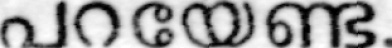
പറയേണ്ട.
